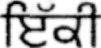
ਇੱਕੀ
